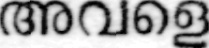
അവളെ
